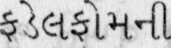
ફડેલફોમની
